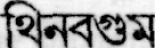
থিনবগুম
